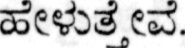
ಹೇಳುತ್ತೇವೆ.
